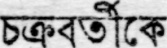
চক্রবর্তীকে
